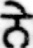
ਨੇ
